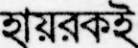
হায়রকই
